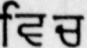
ਵਿਚ
